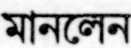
মানলেন
